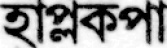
হাপ্লকপা
